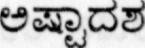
ಅಷ್ಟಾದಶ
